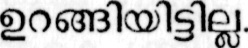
ഉറങ്ങിയിട്ടില്ല.
